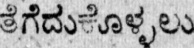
ತೆಗೆದುಕೊಳ್ಳಲು
